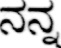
ನನ್ನ
